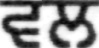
ਵਲ
